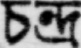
চন্দ্র
